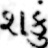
શકું
